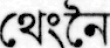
থেংনৈ
